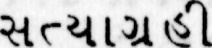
સત્યાગ્રહી
